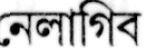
নেলাগিব
